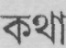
কথা
